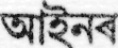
আইনৰ
